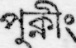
পু্ক্নীং
